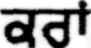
ਕਰਾਂ
